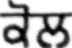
ਕੋਲ
